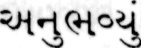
અનુભવ્યું
